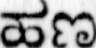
ಹಣ
